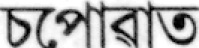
চপোৱাত
